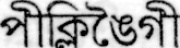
পীক্লৈঙৈগী
